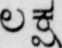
ಲಕ್ಷ
